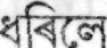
ধৰিলে
